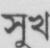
সুখ
